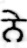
ਨੇ
